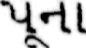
પૂના
